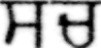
ਸਚ
